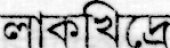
লাকখিদ্রে
